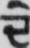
ਦੇ
